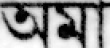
অমা
